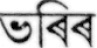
ভৰিৰ
